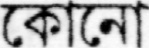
কোনো
